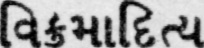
વિક્રમાદિત્ય
